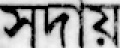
সদায়
